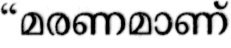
“മരണമാണ്
